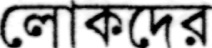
লোকদের
